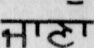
ਜਾਣਾ
